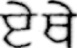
ਏਥੇ
